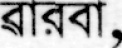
ৱারবা,
